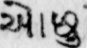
ઓછું
